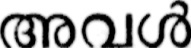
അവള്‍
